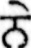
ਨੇ
